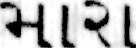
મારા
